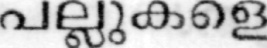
പല്ലുകളെ
